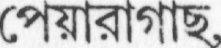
পেয়ারাগাছ,
